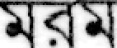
মরম
